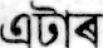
এটাৰ
